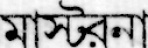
মাস্টরনা
